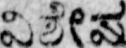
ವಿಶೇಷ
